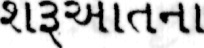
શરૂઆતના
